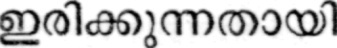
ഇരിക്കുന്നതായി
